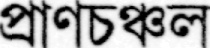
প্রাণচঞ্চল
